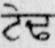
ਟੇਢ
